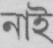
নাই
